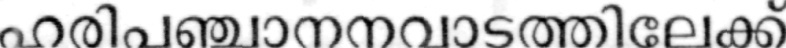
ഹരിപഞ്ചാനനവാടത്തിലേക്ക്
